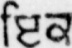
ਇਕ
